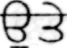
ਉਤੇ
